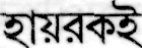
হায়রকই
